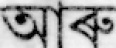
আৰু
